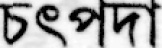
চৎপদা
